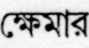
ক্ষেমার
